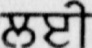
ਲਈ
